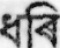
ধৰি
